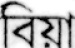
বিয়া
